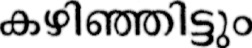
കഴിഞ്ഞിട്ടും
